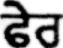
ਫੇਰ
